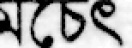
মচেৎ
